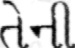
તેની
